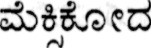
ಮೆಕ್ಸಿಕೋದ
